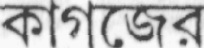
কাগজের
